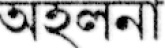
অহলনা
